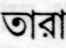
তারা
